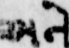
અને
